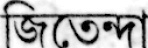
জিতেন্দা
